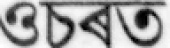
ওচৰত
